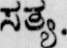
ಸತ್ಯ.
